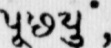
પૂછ્યું,
